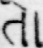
તો
